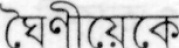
ঘৈণীয়েকে
